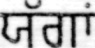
ਯੱਗਾਂ
